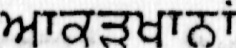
ਆਕੜਖਾਨਾਂ
